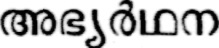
അഭ്യര്‍ഥന
